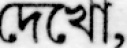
দেখো,
